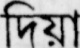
দিয়া
